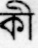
কী
